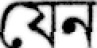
যেন
